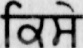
ਕਿਸੇ
